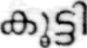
കൂട്ടി
